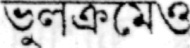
ভুলক্রমেও
